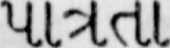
પાત્રતા
